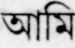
আমি
